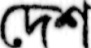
দেশ
